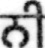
ਨੀ
